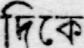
দিকে
